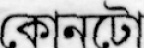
কোনটো
